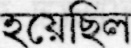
হয়েছিল
